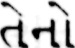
તેનો
